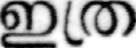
ഇത്ര
